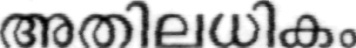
അതിലധികം
